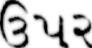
ઉપર
